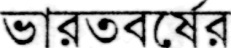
ভারতবর্ষের
